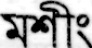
মশীং
